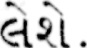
લેશે.
